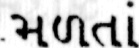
મળતાં
